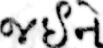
જઈને
